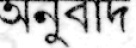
অনুবাদ
